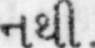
નથી.
